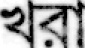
খরা
